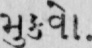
મુકવો.
